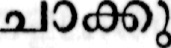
ചാക്കു
